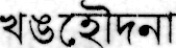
খঙহৌদনা
